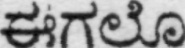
ಈಗಲೊ
